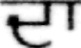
ਦਾ
